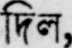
দিল,
